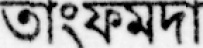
তাংফমদা
